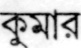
কুমার
